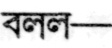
বলল–
